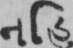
નહિ
